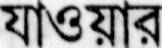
যাওয়ার
